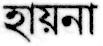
হায়না
